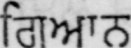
ਗਿਆਨ
